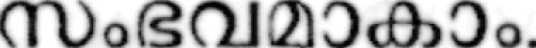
സംഭവമാകാം.
